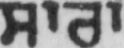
ਸਾਰਾ
